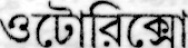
ওটোরিক্সো
